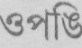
ওপঙি
